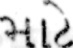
માટે
